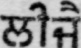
ਲੀਜੈ
